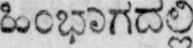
ಹಿಂಭಾಗದಲ್ಲಿ
